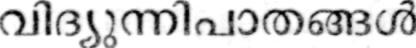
വിദ്യുന്നിപാതങ്ങള്‍
